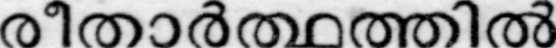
രീതാര്‍ത്ഥത്തില്‍
